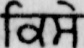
ਕਿਸੇ
